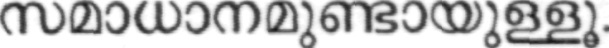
സമാധാനമുണ്ടായുള്ളൂ.
